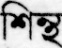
শিন্থ
